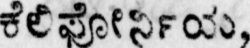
ಕೆಲಿಫೋರ್ನಿಯ,
